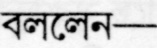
বললেন–
